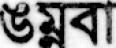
ঙম্নবা
